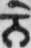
ਨੇ
